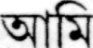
আমি
